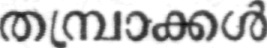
തമ്പ്രാക്കള്‍
